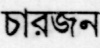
চারজন
